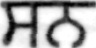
ਸਨ
